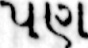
પણ
